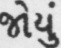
જોયું
